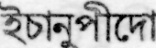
ইচানুপীদো
